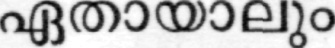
ഏതായാലും
